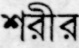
শরীর
